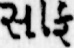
સાફ
